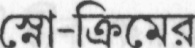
স্নো-ক্রিমের
